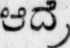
ಆದ್ರೆ
